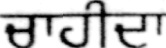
ਚਾਹੀਦਾ
